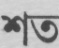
শত
